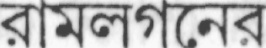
রামলগনের
